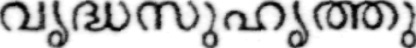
വൃദ്ധസുഹൃത്തു
